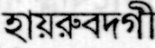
হায়রুবদগী
